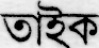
তাইক
